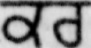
ਕਰ
